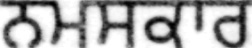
ਨਮਸਕਾਰ
